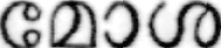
മോശ
